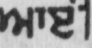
ਆਈ
